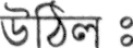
উঠিলঃ
